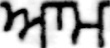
ਆਮ
